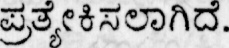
ಪ್ರತ್ಯೇಕಿಸಲಾಗಿದೆ.
